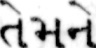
તેમને
